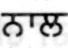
ਨਾਲ
